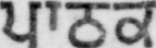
ਪਾਠਕ
